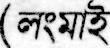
(লংমাই
